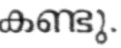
കണ്ടു.
